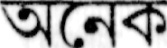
অনেক
